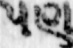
પણ
